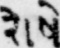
રોષે
